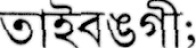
তাইবঙগী;
